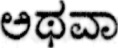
ಅಥವಾ
